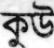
কুউ
